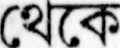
থেকে
